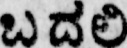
ಬದಲಿ
